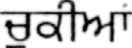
ਚੁਕੀਆਂ
